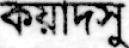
কয়াদসু
